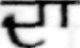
ਦਾ
